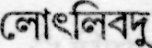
লোৎলিবদু
